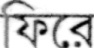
ফিরে
